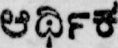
ಆರ್ಥಿಕ
